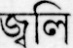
জ্বলি
